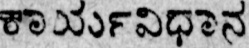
ಕಾರ್ಯವಿಧಾನ
